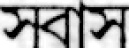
সবাস
